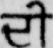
ਦੀ
